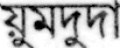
য়ুমদুদা
